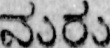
ಮರು
